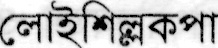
লোইশিল্লকপা
